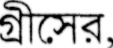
গ্রীসের,
